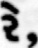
રે,
